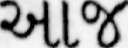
આજ
